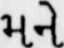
મને
